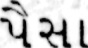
પૈસા
